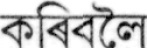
কৰিবলৈ
